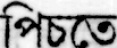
পিচতে
